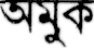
অমুক
